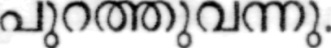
പുറത്തുവന്നു.
